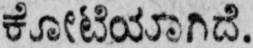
ಕೋಟೆಯಾಗಿದೆ.
